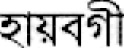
হায়বগী
